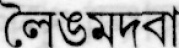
লৈঙমদবা
